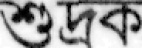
শুদ্রক
